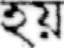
হয়
